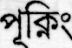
পূক্নিং
